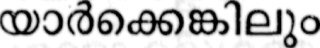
യാര്‍ക്കെങ്കിലും
